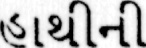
હાથીની
